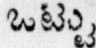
ಒಟ್ಟು
